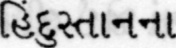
હિંદુસ્તાનના
